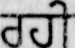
ਰਹੀ
